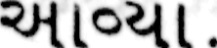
આવ્યા.
